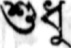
শুধু
